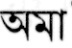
অমা
